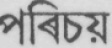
পৰিচয়
